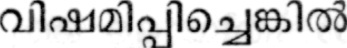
വിഷമിപ്പിച്ചെങ്കില്‍
